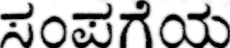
ಸಂಪಗೆಯ
